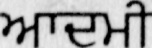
ਆਦਮੀ
